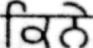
ਕਿਨੇ
